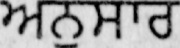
ਅਨੁਸਾਰ
